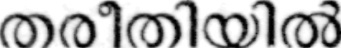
തരീതിയില്‍
